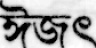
ইজৎ
